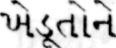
ખેડૂતોને
